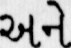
અને
